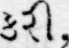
કરી,
